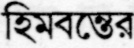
হিমবন্তের
